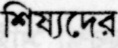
শিষ্যদের
